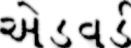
એડવર્ડ
